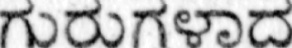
ಗುರುಗಳಾದ
